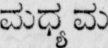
ಮಧ್ಯಮ
